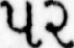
પર
